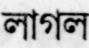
লাগল
